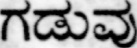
ಗಡುವು
